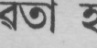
ৱতা
